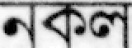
নকল
